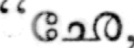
"ഛേ,
